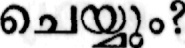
ചെയ്യും?
